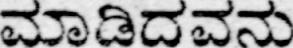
ಮಾಡಿದವನು
